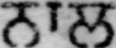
ਨਾਲ
